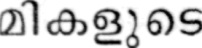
മികളുടെ
